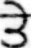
ਤੇ
